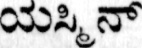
ಯಸ್ಮಿನ್
